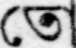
তো
